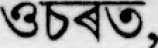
ওচৰত,
